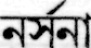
নর্সনা
